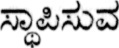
ಸ್ಥಾಪಿಸುವ
